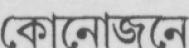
কোনোজনে
